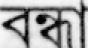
বন্ধা
